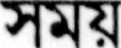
সময়
